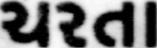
ચરતા
